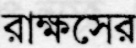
রাক্ষসের
